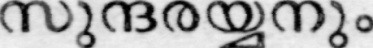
സുന്ദരയ്യനും
